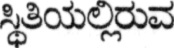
ಸ್ಥಿತಿಯಲ್ಲಿರುವ
